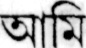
আমি
